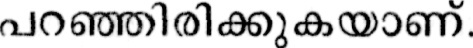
പറഞ്ഞിരിക്കുകയാണ്.
